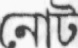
নোট
